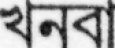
খনবা
